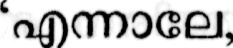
‘എന്നാലേ,
